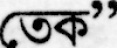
তেক”
